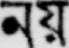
নয়
